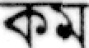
কম
